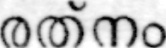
രത്നം
